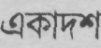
একাদশ
